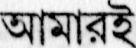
আমারই
